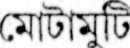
মোটামুটি
